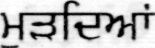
ਮੁੜਦਿਆਂ
